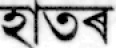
হাতৰ
